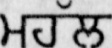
ਮਹੱਲ
